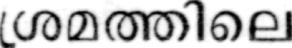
ശ്രമത്തിലെ
